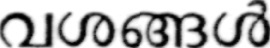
വശങ്ങള്‍
